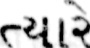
ત્યારે
